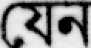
যেন
